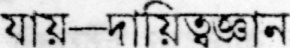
যায়—দায়িত্বজ্ঞান
